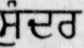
ਸੁੰਦਰ
